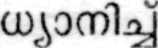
ധ്യാനിച്ച്
